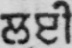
ਲਈ
